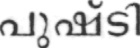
പുഷ്ടി
